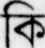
কি
